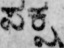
ಪಕ್ಷ
